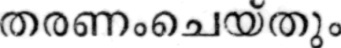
തരണംചെയ്തും
